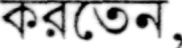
করতেন,
